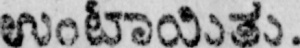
ಉಂಟಾಯಿತು.
